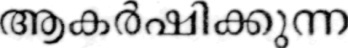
ആകര്‍ഷിക്കുന്ന
